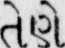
તેણે
